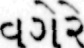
વગેરે
